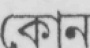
কোন
